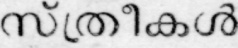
സ്ത്രീകള്‍
